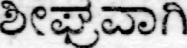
ಶೀಘ್ರವಾಗಿ
